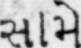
સામે
